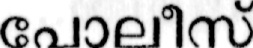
പോലീസ്
